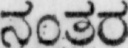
ನಂತರ
